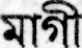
মাগী
